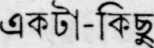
একটা-কিছু
